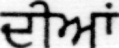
ਦੀਆਂ
